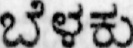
ಬೆಳಕು
